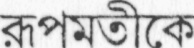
রূপমতীকে
